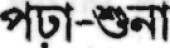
পঢ়া-শুনা
